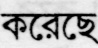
করেছে
